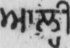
ਆਲ੍ਹੀ
